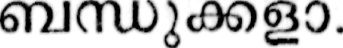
ബന്ധുക്കളാ.
